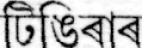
টিঙিৰাৰ
